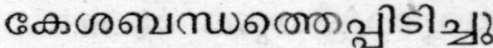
കേശബന്ധത്തെപ്പിടിച്ചു
